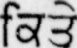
ਕਿਤੇ
